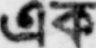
এক
